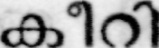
കീറി
